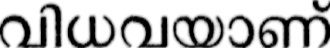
വിധവയാണ്
